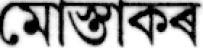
মোস্তাকৰ
